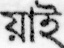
য়াই
